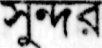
সুন্দর
